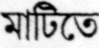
মাটিতে
